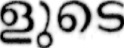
ളുടെ
